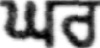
ਘਰ
